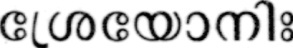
ശ്രേയോനിഃ
